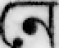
নে
